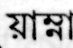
য়াম্না
